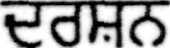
ਦਰਸ਼ਨ
